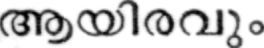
ആയിരവും
